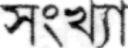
সংখ্যা
